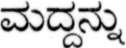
ಮದ್ದನ್ನು
